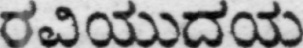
ರವಿಯುದಯ
